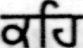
ਕਹਿ
